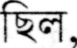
ছিল,
